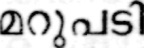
മറുപടി
